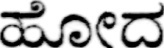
ಹೋದ
